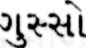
ગુસ્સો
